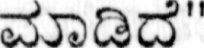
ಮಾಡಿದೆ”
